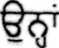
ਉਨ੍ਹਾਂ
